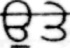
ਉਤੇ
